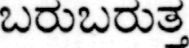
ಬರುಬರುತ್ತ
